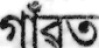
গাঁৱত
